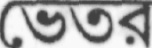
ভেতর
